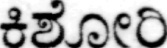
ಕಿಶೋರಿ
